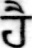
ਹੈ
